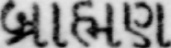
બ્રાહ્મણ
